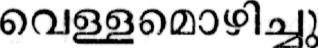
വെള്ളമൊഴിച്ചു
